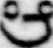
ಆ
